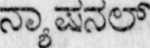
ನ್ಯಾಷನಲ್
